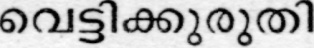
വെട്ടിക്കുരുതി
